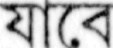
যাবে
